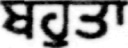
ਬਹੁਤਾ
